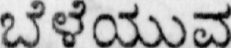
ಬೆಳೆಯುವ
